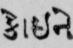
કોઈને
